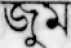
জুম
